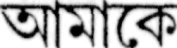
আমাকে
